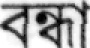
বন্ধা
